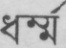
ধৰ্ম্ম
